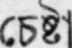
চেষ্টা
